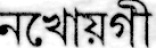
নখোয়গী
